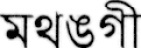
মথঙগী
